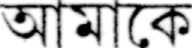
আমাকে
